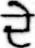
ਦੇ
